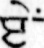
ਏਂ
